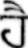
ਹੈ
